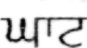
ਘਾਟ
